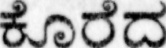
ಕೊರೆದ
